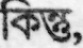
কিন্তু,
